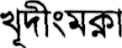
খুদীংমক্না
